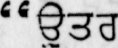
''ਉਤਰ
